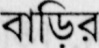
বাড়ির
